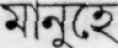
মানুহে
